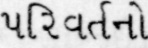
પરિવર્તનો
